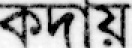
কদায়
